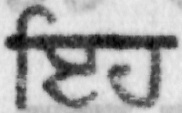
ਇਹ
